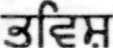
ਭਵਿਸ਼
